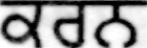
ਕਰਨ
